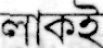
লাকই
